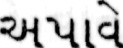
અપાવે
